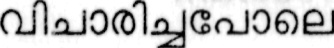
വിചാരിച്ചപോലെ
